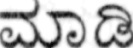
ಮಾಡಿ
